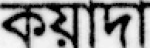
কয়াদা
